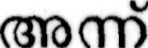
അന്ന്
